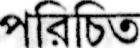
পরিচিত
